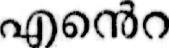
എന്റെ
